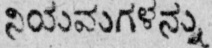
ನಿಯಮಗಳನ್ನು
